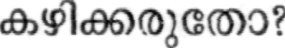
കഴിക്കരുതോ?
